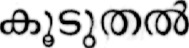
കൂടുതല്‍
